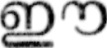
ഈ
